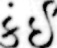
કંઈ
